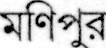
মণিপুর
